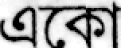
একো
